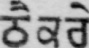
ਠੈਕਰੇ
